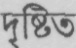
দৃষ্টিত
